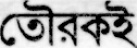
তৌরকই
